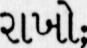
રાખો;
